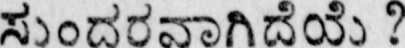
ಸುಂದರವಾಗಿದೆಯೆ?
